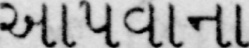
આપવાના
